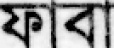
ফাবা
